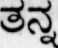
ತನ್ನ
